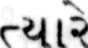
ત્યારે
